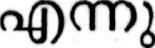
എന്നു
